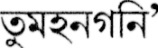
তুমহনগনি’
